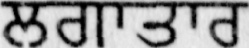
ਲਗਾਤਾਰ
